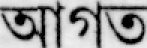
আগত
